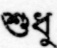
শুধু
